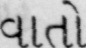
વાતો
